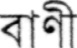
বাণী
